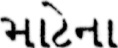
માટેના
